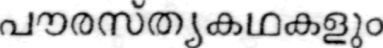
പൌരസ്ത്യകഥകളും
